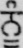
ਨੂੰ
